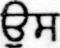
ਉਸ
